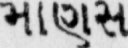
માણસ
